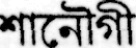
শানৌগী
